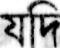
যদি
